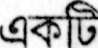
একটি
